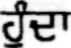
ਹੁੰਦਾ
